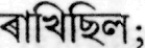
ৰাখিছিল;
